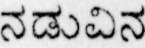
ನಡುವಿನ
